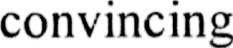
convincing
